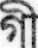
গী
